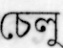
চেলু
